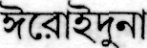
ঈরোইদুনা
